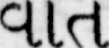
વાત
